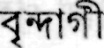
বৃন্দাগী
